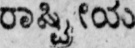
ರಾಷ್ಟ್ರೀಯ
